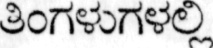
ತಿಂಗಳುಗಳಲ್ಲಿ
